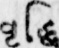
વૃદ્ધિ
